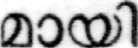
മായി
